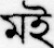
মই
